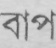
বাপ
